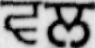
ਵਲ
